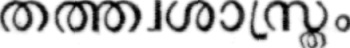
തത്ത്വശാസ്ത്രം
